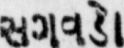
સગવડો
